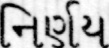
નિર્ણય
